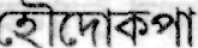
হৌদোকপা
